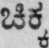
ಚಿಕ್ಕ
